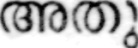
അതു
